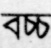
বচ্চ
